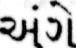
અંગે
